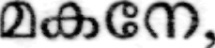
മകനേ,
